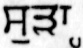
ਸੁੜ੍ਹਾ
